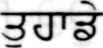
ਤੁਹਾਡੇ
